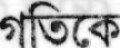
গতিকে
